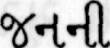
જનની
